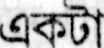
একটা
